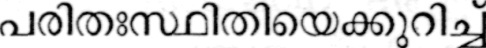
പരിതഃസ്ഥിതിയെക്കുറിച്ച്
